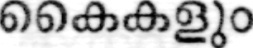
കൈകളും
